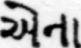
એના
